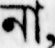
না,
